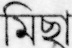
মিছা
